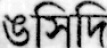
ঙসিদি
